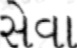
સેવા
